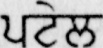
ਪਟੇਲ
